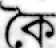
কৈ
